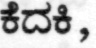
ಕೆದಕಿ,
